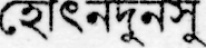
হোৎনদুনসু
